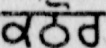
ਕਠੋਰ
